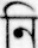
নি
